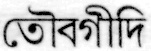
তৌবগীদি
